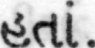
હતાં.
